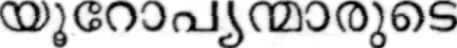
യൂറോപ്യന്മാരുടെ
